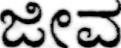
ಜೀವ
